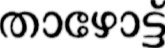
താഴോട്ട്
